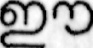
ഈ
